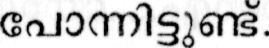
പോന്നിട്ടുണ്ട്.
